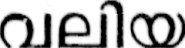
വലിയ
